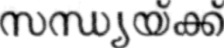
സന്ധ്യയ്ക്ക്
